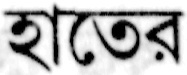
হাতের
